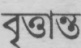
বৃত্তান্ত
